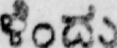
ಳೆಂದು
